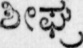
ಶೀಘ್ರ
